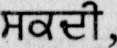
ਸਕਦੀ,
